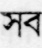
সব
